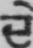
ਦੇ
